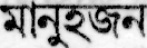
মানুহজন
